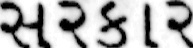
સરકાર
